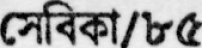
সেবিকা/৮৫
